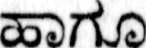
ಹಾಗೂ
